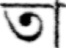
তা
